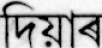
দিয়াৰ
